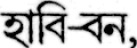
হাবি-বন,
